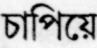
চাপিয়ে
